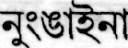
নুংঙাইনা
